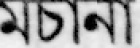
মচানা
